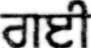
ਗਈ
